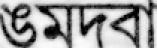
ঙমদবা
